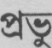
প্ৰভু
